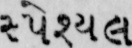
સ્પેશ્યલ
